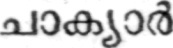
ചാക്യാര്‍
